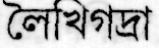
লৈখিগদ্রা
